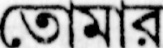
তোমার
